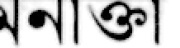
মনাক্তা
